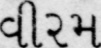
વીરમ
